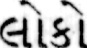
લોકો
